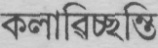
কলাৱিচ্ছন্তি
